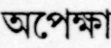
অপেক্ষা
